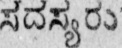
ಸದಸ್ಯರು
